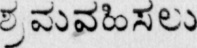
ಶ್ರಮವಹಿಸಲು
